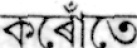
কৰোঁতে
